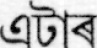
এটাৰ
